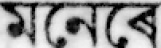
মনেৰে
